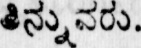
ತಿನ್ನುವರು.
